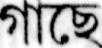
গাছে
